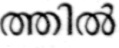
ത്തില്‍
